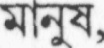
মানুষ,
